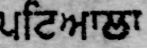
ਪਟਿਆਲਾ
